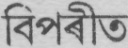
বিপৰীত
